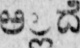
ಅಲ್ಲದೆ
